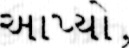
આપ્યો,
